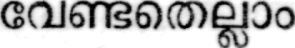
വേണ്ടതെല്ലാം
